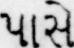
પાસે
